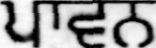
ਪਾਵਨ
